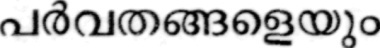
പര്‍വതങ്ങളെയും
